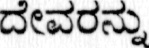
ದೇವರನ್ನು
